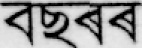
বছৰৰ
